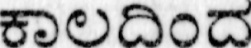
ಕಾಲದಿಂದ
